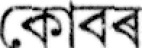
কোবৰ
